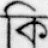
কি
